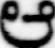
ಆ
